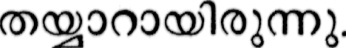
തയ്യാറായിരുന്നു.
